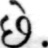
છે.
